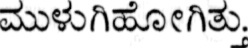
ಮುಳುಗಿಹೋಗಿತ್ತು.
